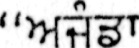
''ਅਜੰਡਾ
